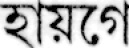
হায়গে
